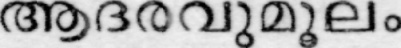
ആദരവുമൂലം
